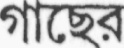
গাছের
